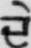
ਦੇ
